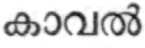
കാവല്‍
